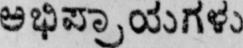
ಅಭಿಪ್ರಾಯಗಳು
